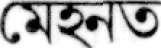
মেহনত
